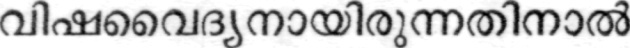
വിഷവൈദ്യനായിരുന്നതിനാല്‍
